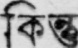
কিন্তু
